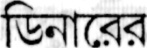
ডিনারের
